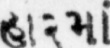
હારમાં
